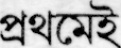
প্রথমেই
